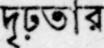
দৃঢ়তার
